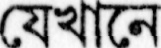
যেখানে
